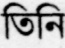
তিনি
